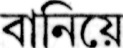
বানিয়ে
